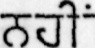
ਨਹੀਂ
